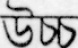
উচ্চ
